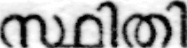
സ്ഥിതി
